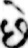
છે
